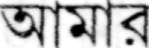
আমার
